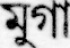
মুগা
